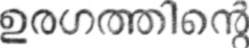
ഉരഗത്തിന്റെ
